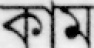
কাম
